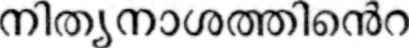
നിത്യനാശത്തിന്റെ
